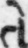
તે
